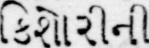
કિશોરીની
